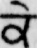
ਕੇ
